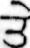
ਤੇ
